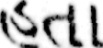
હતા
